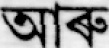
আৰু
